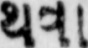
થવા
